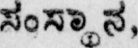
ಸಂಸ್ಥಾನ,
